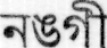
নঙগী
